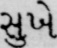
સુખે
